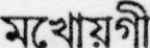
মখোয়গী
